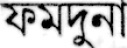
ফমদুনা
